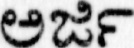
ಅರ್ಜಿ
